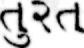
તુરત
